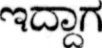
ಇದ್ದಾಗ
